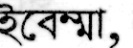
‘ইবেম্মা,
